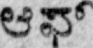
ಆಫ್
